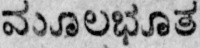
ಮೂಲಭೂತ
